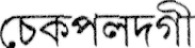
চেকপলদগী
